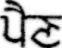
ਪੈਣ
